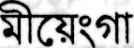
মীয়েংগা
